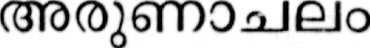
അരുണാചലം
